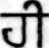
ਹੀ
